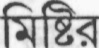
মিষ্টির
